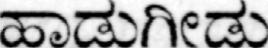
ಹಾಡುಗೀಡು
